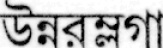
উন্নরম্লগা
